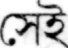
সেই
